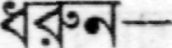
ধরুন-
